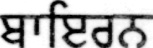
ਬਾਇਰਨ
